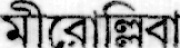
মীরোল্লিবা
